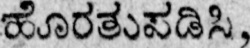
ಹೊರತುಪಡಿಸಿ,
